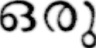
ഒരു
